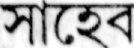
সাহেব
